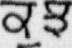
ਕੁਝ
